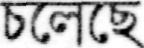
চলেছে
